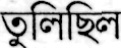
তুলিছিল
